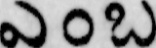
ಎಂಬ
